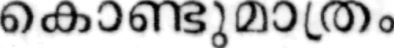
കൊണ്ടുമാത്രം
